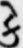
કે
